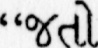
"જતો
